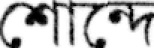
শোন্দে
